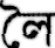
লৈ
